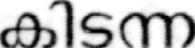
കിടന്ന
